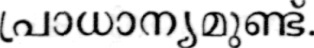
പ്രാധാന്യമുണ്ട്.
